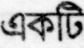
একটি
